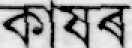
কাষৰ
